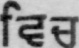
ਵਿਚ
